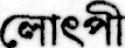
লোৎপী
